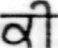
ਕੀ
